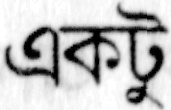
একটু
